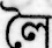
লৈ
